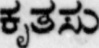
ಕೃತಸು
